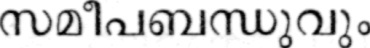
സമീപബന്ധുവും
